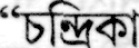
“চন্দ্রিকা
